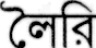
লৈরি
